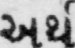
અર્થ
